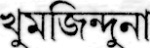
খুমজিন্দুনা
